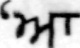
'ਆ
